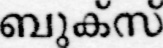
ബുക്സ്
